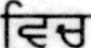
ਵਿਚ
